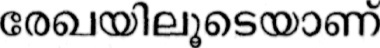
രേഖയിലൂടെയാണ്
